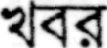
খবর
